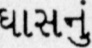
ઘાસનું
